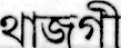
থাজগী
